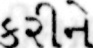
કરીને
